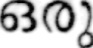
ഒരു
